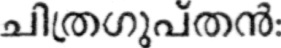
ചിത്രഗുപ്തന്‍:
